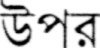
উপর
